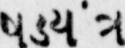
ષડયંત્ર
